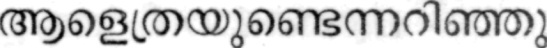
ആളെത്രയുണ്ടെന്നറിഞ്ഞു
